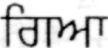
ਗਿਆ
